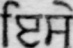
ਇਸੇ
